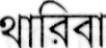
থারিবা
